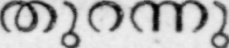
തുറന്നു
